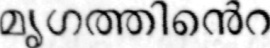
മൃഗത്തിന്റെ
